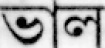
ভাল
